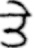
ਤੇ
